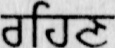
ਰਹਿਣ
